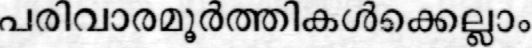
പരിവാരമൂര്‍ത്തികള്‍ക്കെല്ലാം
